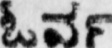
ಓರ್ವ
